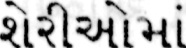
શેરીઓમાં
